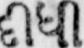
દીધી
